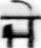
ਜੇ
